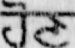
ਹੋਣ
